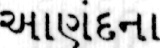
આણંદના
